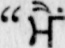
''ਮੈਂ
